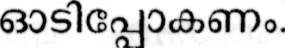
ഓടിപ്പോകണം.
